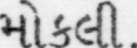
મોકલી.
